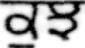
ਕੁਝ
